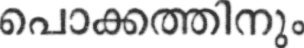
പൊക്കത്തിനും
